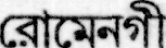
রোমেনগী
